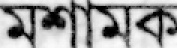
মশামক
